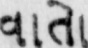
વાતો
